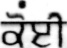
ਕੋਈ
